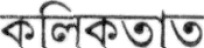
কলিকতাত
